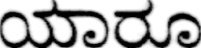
ಯಾರೂ
